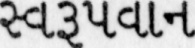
સ્વરૂપવાન
